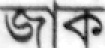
জাক
